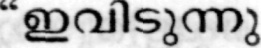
"ഇവിടുന്നു
